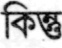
কিন্তু
